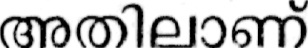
അതിലാണ്
